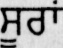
ਸੂਰਾਂ
